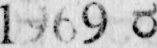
1969ರ
